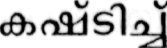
കഷ്ടിച്ച്
